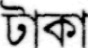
টাকা
